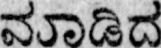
ಮಾಡಿದ
